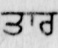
ਤਾਰ
